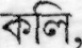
কলি,
